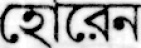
হোরেন
